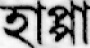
হাপ্পা
